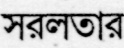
সরলতার
